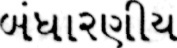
બંધારણીય
